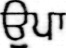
ਉਪਾ
